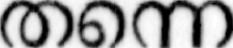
തന്നെ
